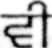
ਵੀ
